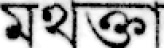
মথক্তা
